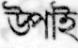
উপাই
